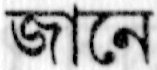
জানে
